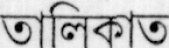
তালিকাত
